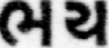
ભય
